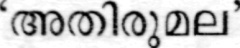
‘അതിരുമല’
